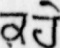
ਕਹੇ
